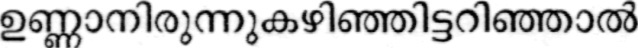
ഉണ്ണാനിരുന്നുകഴിഞ്ഞിട്ടറിഞ്ഞാല്‍
